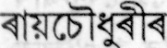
ৰায়চৌধুৰীৰ
